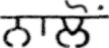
ਨਾਲੋਂ
